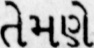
તેમણે
